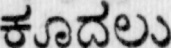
ಕೂದಲು
